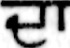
ਦਾ
